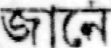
জানে
